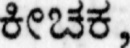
ಕೀಚಕ,
